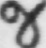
જ
